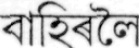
বাহিৰলৈ
